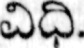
ವಿಧಿ.
